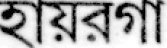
হায়রগা
